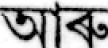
আৰু
